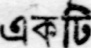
একটি
